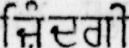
ਜ਼ਿੰਦਗੀ
